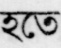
হতে
